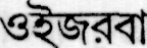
ওইজরবা
